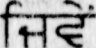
ਜਿਵੇਂ
